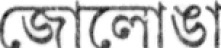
জোলোঙা
